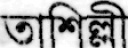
তাশিল্লী
